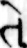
તે
